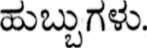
ಹುಬ್ಬುಗಳು.
